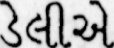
ડેલીએ
